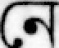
নে
